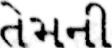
તેમની
